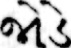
જોડે
